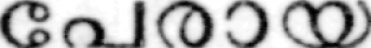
പേരായ
